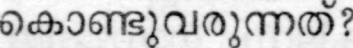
കൊണ്ടുവരുന്നത്?
